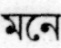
মনে
